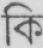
কি
